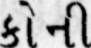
કોની
